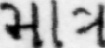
માત્ર
